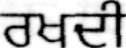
ਰਖਦੀ
